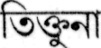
তিক্তুনা
